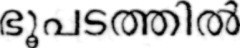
ഭൂപടത്തില്‍
